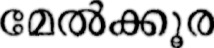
മേല്‍ക്കൂര
